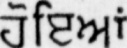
ਹੋਇਆਂ
